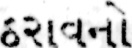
ઠરાવનો
